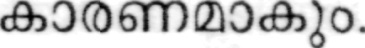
കാരണമാകും.
